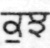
ਕੁਝ
